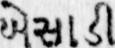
બેસાડી
